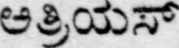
ಅತ್ರಿಯಸ್
